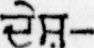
ਦੇਸ਼-
